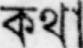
কথা
